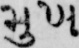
મુખ
